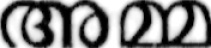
അമ്മ
